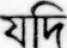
যদি
